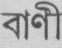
বাণী
